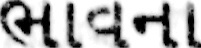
ભાવના
